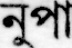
নুপা
